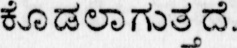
ಕೊಡಲಾಗುತ್ತದೆ.
